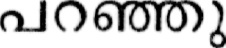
പറഞ്ഞു
